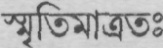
স্মৃতিমাত্ৰতঃ
